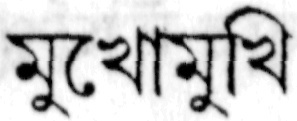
মুখোমুখি
